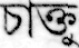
চাক্তু
